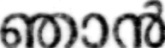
ഞാന്‍
